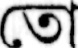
তো
